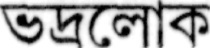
ভদ্রলোক
